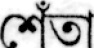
শেঁতা
